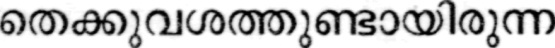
തെക്കുവശത്തുണ്ടായിരുന്ന
